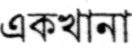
একখানা
